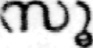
സൂ
